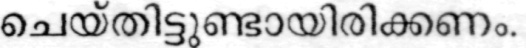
ചെയ്തിട്ടുണ്ടായിരിക്കണം.
